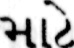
માટે
